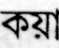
কয়া
